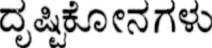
ದೃಷ್ಟಿಕೋನಗಳು
